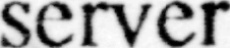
server
